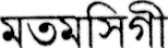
মতমসিগী
